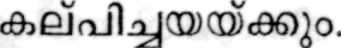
കല്പിച്ചയയ്ക്കും.
